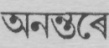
অনন্তৰে
